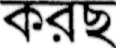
করছ
